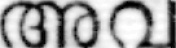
അവ
